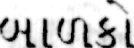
બાળકો
